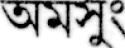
অমসুং
